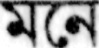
মনে
